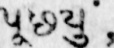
પૂછ્યું,
